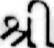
શ્રી
